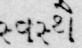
સ્વસ્થૈ
